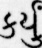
કર્યું
